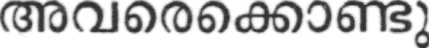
അവരെക്കൊണ്ടു
